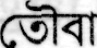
তৌবা
